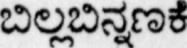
ಬಿಲ್ಲಬಿನ್ನಣಕೆ
